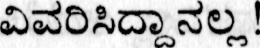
ವಿವರಿಸಿದ್ದಾನಲ್ಲ!
